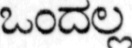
ಒಂದಲ್ಲ
